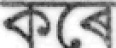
কৰে
